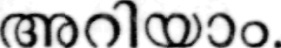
അറിയാം.
